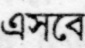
এসবে
